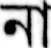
না
